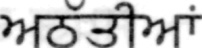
ਅਠੱਤੀਆਂ
